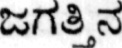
ಜಗತ್ತಿನ
